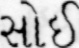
સોઈ
